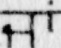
ਜਾਂ
